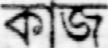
কাজ
